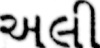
અલી
